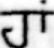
ਹਾਂ
